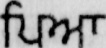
ਪਿਆ
